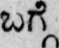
ಬಗ್ಗೆ
